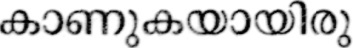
കാണുകയായിരു
